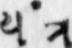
યંત્ર
